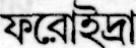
ফরোইদ্রা
